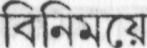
বিনিময়ে
